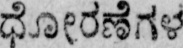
ಧೋರಣೆಗಳ
